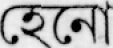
হেনো
